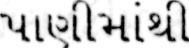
પાણીમાંથી
